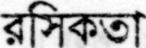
রসিকতা
